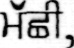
ਮੱਛੀ,
